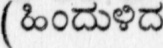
(ಹಿಂದುಳಿದ
